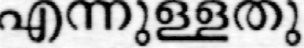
എന്നുള്ളതു
